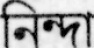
নিন্দা
